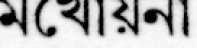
মখোয়না
